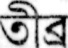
তীব্র
